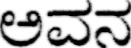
ಅವನ
